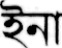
ইনা
